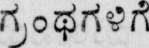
ಗ್ರಂಥಗಳಿಗೆ
